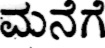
ಮನೆಗೆ
